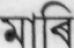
মাৰি
